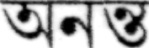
অনন্ত
